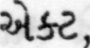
એક્ટ,
